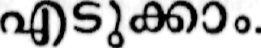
എടുക്കാം.
